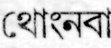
থোংনবা
